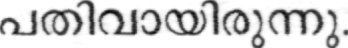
പതിവായിരുന്നു.
